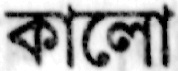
কালো
